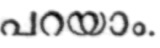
പറയാം.
